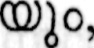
യും,
